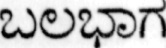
ಬಲಭಾಗ
